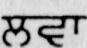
ਲਵਾ
